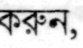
করুন,
